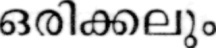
ഒരിക്കലും
